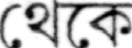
থেকে
